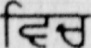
ਵਿਚ
